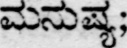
ಮನುಷ್ಯ;
